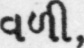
વળી,
